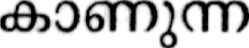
കാണുന്ന
